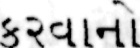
કરવાનો
